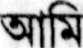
আমি
